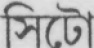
সিটো
